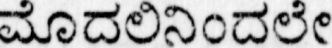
ಮೊದಲಿನಿಂದಲೇ
